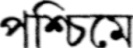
পশ্চিমে
